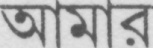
আমার
